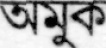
অমুক
